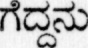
ಗೆದ್ದನು
